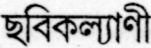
ছবিকল্যাণী
